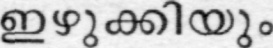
ഇഴുക്കിയും
